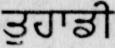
ਤੁਹਾਡੀ
